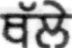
ਥੱਲੇ
